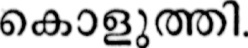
കൊളുത്തി.
